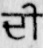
ਦੀ
